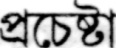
প্রচেষ্টা
